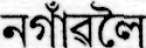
নগাঁৱলৈ
